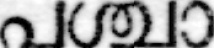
പശ്ചാ
